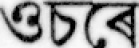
ওচৰে
